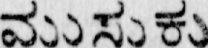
ಮುಸುಕು
